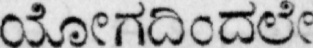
ಯೋಗದಿಂದಲೇ
